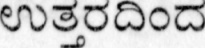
ಉತ್ತರದಿಂದ
